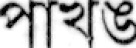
পাখঙ
